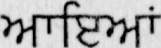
ਆਇਆਂ
